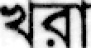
খরা
